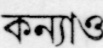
কন্যাও
